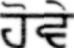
ਹੋਵੇ
